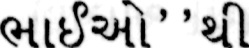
ભાઈઓ"થી
